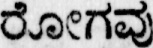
ರೋಗವು
